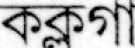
কক্লগা
